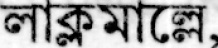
লাক্লমাল্লে,
